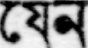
যেন
